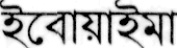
ইবোয়াইমা
